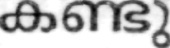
കണ്ടു
